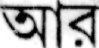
আর
